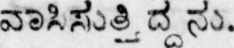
ವಾಸಿಸುತ್ತಿದ್ದನು.
